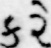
કરે
